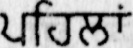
ਪਹਿਲਾਂ
